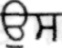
ਉਸ
